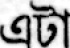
এটা
